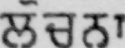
ਲੋਚਨਾ
